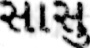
સાસુ
